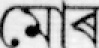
মোৰ
